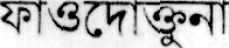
ফাওদোক্তুনা
